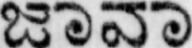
ಜಾವಾ
